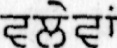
ਵਲੇਵਾਂ
